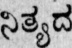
ನಿತ್ಯದ
